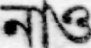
নাও
